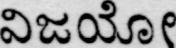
ವಿಜಯೋ
